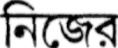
নিজের
